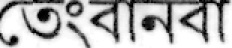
তেংবানবা
